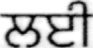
ਲਈ
